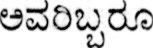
ಅವರಿಬ್ಬರೂ
